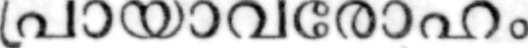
പ്രായാവരോഹം
